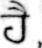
ਹੈ,
